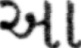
આ
